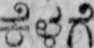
ಕೆಳಗೆ
